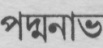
পদ্মনাভ
